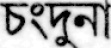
চংদুনা
